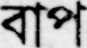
বাপ
